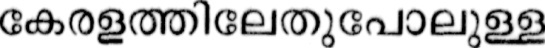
കേരളത്തിലേതുപോലുള്ള
